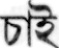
চাই
